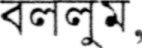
বললুম,
